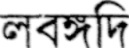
লবঙ্গদি
